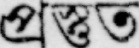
প্রস্তুত
